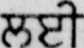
ਲਈ
